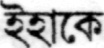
ইহাকে
